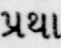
પ્રથા
